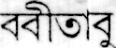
ববীতাবু
